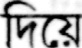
দিয়ে
